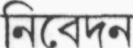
নিবেদন
